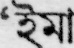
‘ইমা
